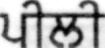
ਪੀਲੀ
